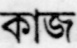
কাজ
